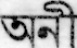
অনী
